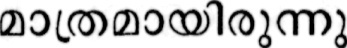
മാത്രമായിരുന്നു
